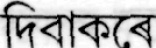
দিবাকৰে
